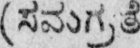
(ಸಮಗ್ರತೆ
